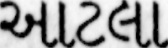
આટલા
